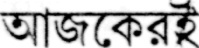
আজকেরই
